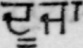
ਦੂਜਾ
